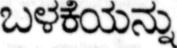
ಬಳಕೆಯನ್ನು
